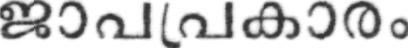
ജാപപ്രകാരം
